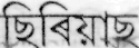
ছিৰিয়াছ
